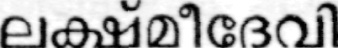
ലക്ഷ്മീദേവി
